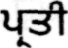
ਪ੍ਰਤੀ
